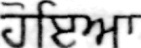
ਹੋਇਆ
